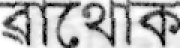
ৱাথোক
